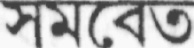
সমবেত
